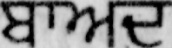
ਬਾਅਦ
